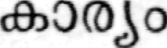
കാര്യം
